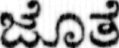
ಜೊತೆ
